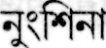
নুংশিনা
